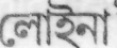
লোইনা
